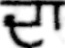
ਦਾ
